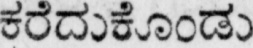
ಕರೆದುಕೊಂಡು
